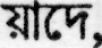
য়াদে,
